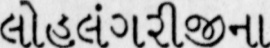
લોહલંગરીજીના
